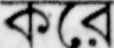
করে
